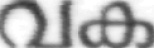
വക
